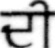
ਦੀ
